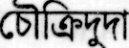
চৌক্রিদুদা
